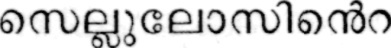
സെല്ലുലോസിന്റെ
